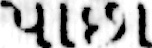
પાછા
